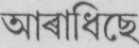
আৰাধিছে
